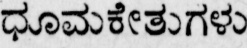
ಧೂಮಕೇತುಗಳು
